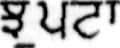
ਝੁਪਟਾ
